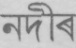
নদীৰ
